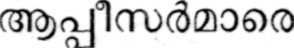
ആപ്പീസര്‍മാരെ
